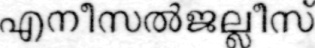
എനീസല്‍ജല്ലീസ്
